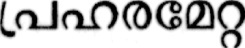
പ്രഹരമേറ്റ
